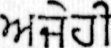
ਅਜੇਹੀ
